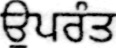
ਉਪਰੰਤ
